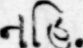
નહિ.
